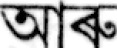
আৰু
